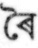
ৰৈ
